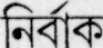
নির্বাক
